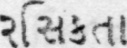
રસિકતા
